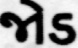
જોડ
